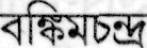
বঙ্কিমচন্দ্র
